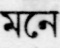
মনে
